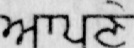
ਆਪਣੇ
